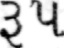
રૂપ
